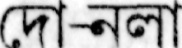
দো-নলা
